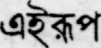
এইরূপ
